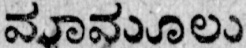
ಮಾಮೂಲು
